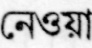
নেওয়া
